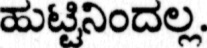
ಹುಟ್ಟಿನಿಂದಲ್ಲ.
